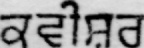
ਕਵੀਸ਼ਰ
